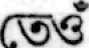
তেওঁ
